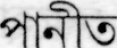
পানীত
